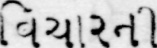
વિચારની
